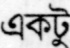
একটু
